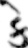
કે
